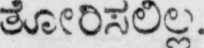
ತೋರಿಸಲಿಲ್ಲ.
